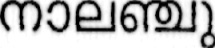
നാലഞ്ചു
